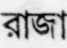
রাজা
